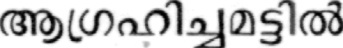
ആഗ്രഹിച്ചമട്ടില്‍
